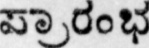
ಪ್ರಾರಂಭ
